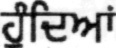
ਹੁੰਦਿਆਂ
